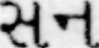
સન
